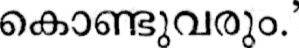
കൊണ്ടുവരും.'
